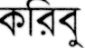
করিবু
